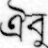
ঐবু
